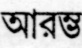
আরম্ভ
